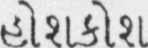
હોશકોશ
